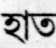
হাত
